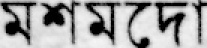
মশমদো
